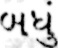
બધું
